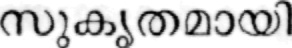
സുകൃതമായി
